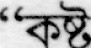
"কষ্ট
